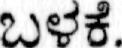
ಬಳಕೆ.
